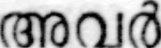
അവര്‍
